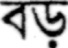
বড়
